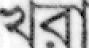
খরা
